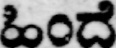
ಹಿ೦ದೆ
